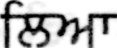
ਲਿਆ
